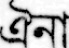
ঐনা
